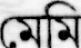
মেমি
